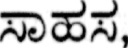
ಸಾಹಸ,
